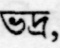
ভদ্র,
